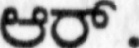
ಆರ್.
